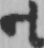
ન
